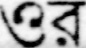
ওর
